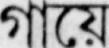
গায়ে
